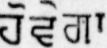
ਹੋਵੇਗਾ
